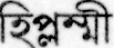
হিপ্লম্মী
